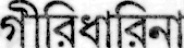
গীরিধারিনা
